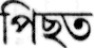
পিছত
